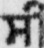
ਸੀ
